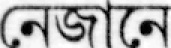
নেজানে
